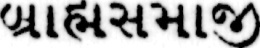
બ્રાહ્મસમાજી
